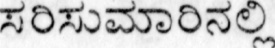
ಸರಿಸುಮಾರಿನಲ್ಲಿ
